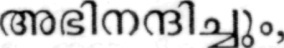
അഭിനന്ദിച്ചും,
